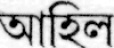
আহিল
